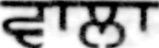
ਵਾਲਾ
